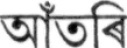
আঁতৰি
